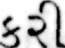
કરી
